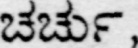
ಚರ್ಚು,
